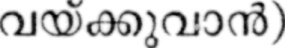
വയ്ക്കുവാന്‍)
